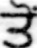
ਤੋਂ
